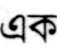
এক
